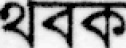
থবক
